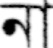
না
